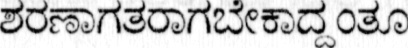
ಶರಣಾಗತರಾಗಬೇಕಾದ್ದಂತೂ
